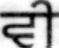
ਵੀ
